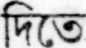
দিতে
